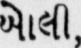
બોલી,
